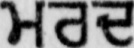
ਮਰਦ
